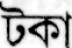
টকা
